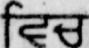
ਵਿਚ
